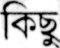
কিছু
